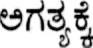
ಅಗತ್ಯಕ್ಕೆ
